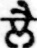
ਲੈ
